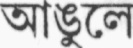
আঙুলে
